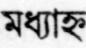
মধ্যাহ্ন
